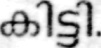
കിട്ടി.
